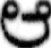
ಆ
